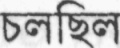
চলছিল
